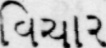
વિચાર
